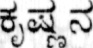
ಕೃಷ್ಣನ
